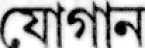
যোগান
